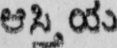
ಆಸ್ತಿಯ
